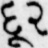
દૂર
